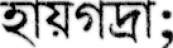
হায়গদ্রা;
